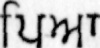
ਪਿਆ
